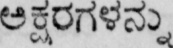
ಅಕ್ಷರಗಳನ್ನು
